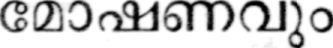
മോഷണവും
